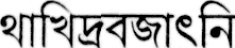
থাখিদ্রজাৎনি
